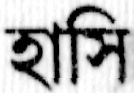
হাসি
